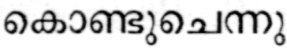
കൊണ്ടുചെന്നു
